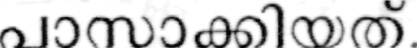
പാസാക്കിയത്.
